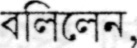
বলিলেন,
